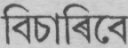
বিচাৰিবে
